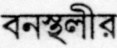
বনস্থলীর
